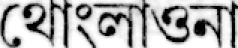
থোংলাওনা
